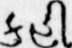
કહી
